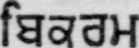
ਬਿਕਰਮ
